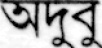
অদুবু
